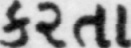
કરતા
